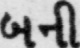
બની
